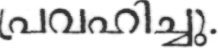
പ്രവഹിച്ചു.
